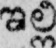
ಇಲ್ಲಿ
